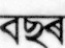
বছৰ
